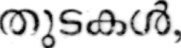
തുടകള്‍,
